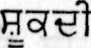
ਸ਼ੂਕਦੀ
